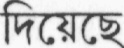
দিয়েছে
